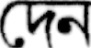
দেন
